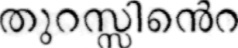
തുറസ്സിന്റെ
